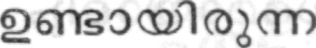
ഉണ്ടായിരുന്ന
